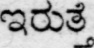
ಇರುತ್ತೆ
